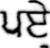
ਪਏ
